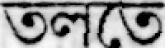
তলতে
